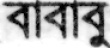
বাবাবু
